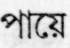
পায়ে
